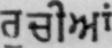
ਰੁਚੀਆਂ
